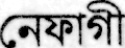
নেফাগী
